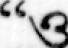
“ও
